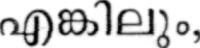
എങ്കിലും,
